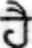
ਹੈ
